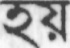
হয়
